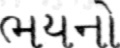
ભયનો
